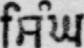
ਸਿੰਘ
